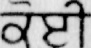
ਕੋਈ
